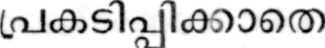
പ്രകടിപ്പിക്കാതെ
